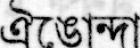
ঐঙোন্দা
